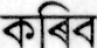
কৰিব
